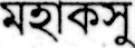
মহাকসু
